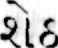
શેઠ
